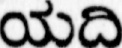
ಯದಿ
